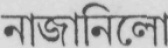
নাজানিলো
